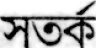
সতর্ক
